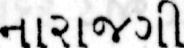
નારાજગી
